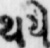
થયે
